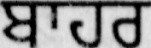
ਬਾਹਰ
